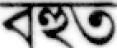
বহুত
